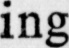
ing
